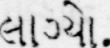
લાગ્યો.
